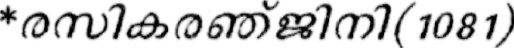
*രസികരഞ്ജിനി(1081)
